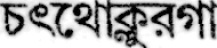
চৎথোক্লুরগা
